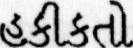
હકીકતો
